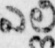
ಎಲ್ಲಿ
